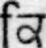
ਕਿ
